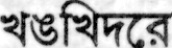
খঙখিদরে
